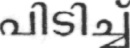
പിടിച്ച്
